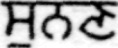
ਸੁਨਣ
